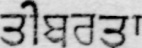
ਤੀਬਰਤਾ
